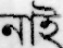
নাই
